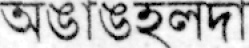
অঙাঙহলদা
